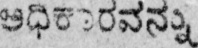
ಅಧಿಕಾರವನ್ನು
